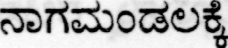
ನಾಗಮಂಡಲಕ್ಕೆ
